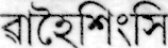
ৱাহৈশিংসি
